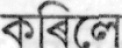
কৰিলে
